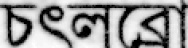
চৎলব্রো
